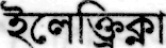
ইলেক্ত্রিক্না
